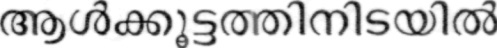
ആള്‍ക്കൂട്ടത്തിനിടയില്‍
